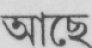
আছে
